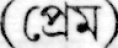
(প্রেম)
